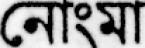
নোংমা
